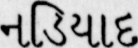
નડિયાદ
